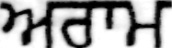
ਅਰਾਮ
